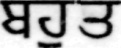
ਬਹੁਤ
